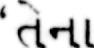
'તેના
